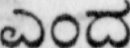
ಎಂದ
